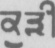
ਕੁੜੀ
